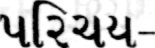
પરિચય-
